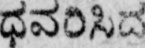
ಧವರಿಸಿದ
